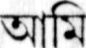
আমি
